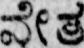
ವೇತ
